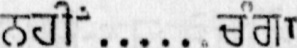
ਨਹੀਂ..........ਚੰਗਾ
